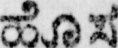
ಹೊಸ
